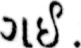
ગઈ.
